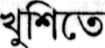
খুশিতে
